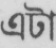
এটা
